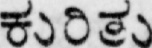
ಕುರಿತು
